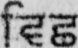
ਵਿਛ
